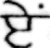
ਏਂ
